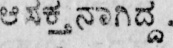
ಆಸಕ್ತನಾಗಿದ್ದ.
